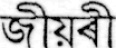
জীয়ৰী
